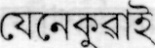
যেনেকুৱাই
